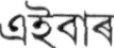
এইবাৰ
